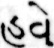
હવે
